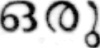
ഒരു
